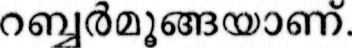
റബ്ബര്‍മൂങ്ങയാണ്.
